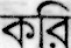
করি
